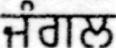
ਜੰਗਲ
